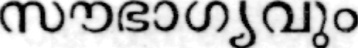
സൌഭാഗ്യവും
